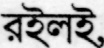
রইলই,
